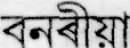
বনৰীয়া
